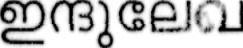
ഇന്ദുലേഖ
